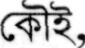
কৌই,
